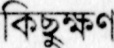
কিছুক্ষণ
